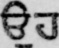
ਉਹ
